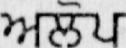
ਅਲੋਪ
